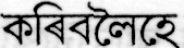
কৰিবলৈহে
